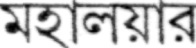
মহালয়ার
